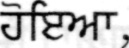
ਹੋਇਆ,
